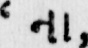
'ના,
